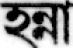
হন্না
